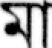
মা
